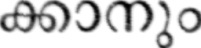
ക്കാനും
